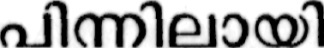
പിന്നിലായി
